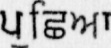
ਪੁਛਿਆ
